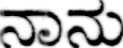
ನಾನು
